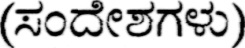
(ಸಂದೇಶಗಳು)
